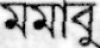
মমাবু
